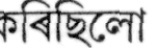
কৰিছিলো
